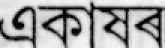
একাষৰ
